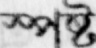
স্পষ্ট
